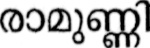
രാമുണ്ണി
